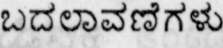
ಬದಲಾವಣೆಗಳು
